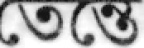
তেন্তে
